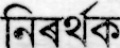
নিৰর্থক
